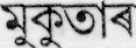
মুকুতাৰ
